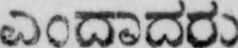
ಎಂದಾದರು
